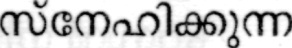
സ്നേഹിക്കുന്ന
